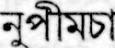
নুপীমচা
